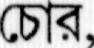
চোর,
